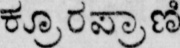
ಕ್ರೂರಪ್ರಾಣಿ
